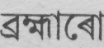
ব্ৰহ্মাৰো
